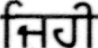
ਜਿਹੀ
